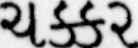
ચક્કર
